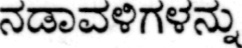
ನಡಾವಳಿಗಳನ್ನು
